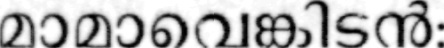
മാമാവെങ്കിടന്‍:
